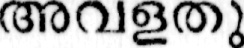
അവളതു
